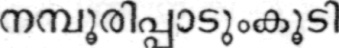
നമ്പൂരിപ്പാടുംകൂടി
